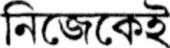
নিজেকেই
